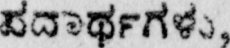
ಪದಾರ್ಥಗಳು,
